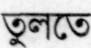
তুলতে
